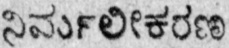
ನಿರ್ಮಲೀಕರಣ
